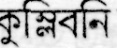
কুম্লিবনি
